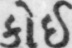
કોઈ
